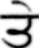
ਤੇ
